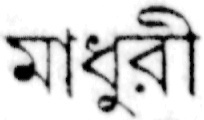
মাধুরী
